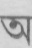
অ
